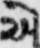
એ
